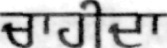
ਚਾਹੀਦਾ
